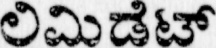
ಲಿಮಿಡೆಟ್
